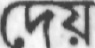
দেয়
